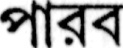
পারব
